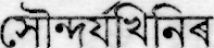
সৌন্দযখিনিৰ
